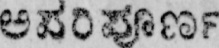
ಅಪರಿಪೂರ್ಣ
